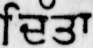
ਦਿੱਤਾ
